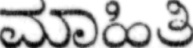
ಮಾಹಿತಿ
